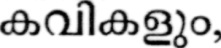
കവികളും,
